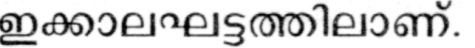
ഇക്കാലഘട്ടത്തിലാണ്.
